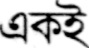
একই
